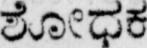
ಶೋಧಕ
